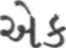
એક
